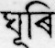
ঘূৰি
